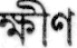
ক্ষীণ
